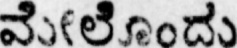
ಮೇಲೊಂದು
